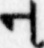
ન
